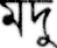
মদু
